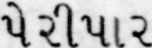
પેરીપાર
